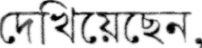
দেখিয়েছেন,
